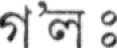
গ'লঃ
